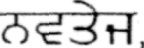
ਨਵਤੇਜ,
